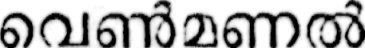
വെണ്‍മണല്‍
